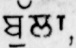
ਬੁੱਲਾ,
